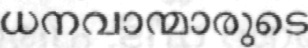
ധനവാന്മാരുടെ
